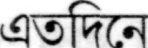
এতদিনে
